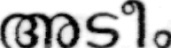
അടീം
